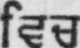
ਵਿਚ
